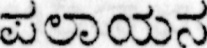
ಪಲಾಯನ
